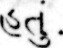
હતું.
